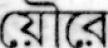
য়ৌরে
